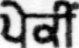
ਪੇਕੀਂ
